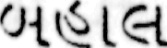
બહાલ
